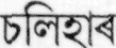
চলিহাৰ
